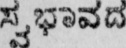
ಸ್ವಭಾವದ
